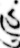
હું
